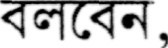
বলবেন,
